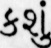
કશું
